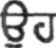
ਉਹ
